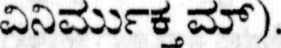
ವಿನಿರ್ಮುಕ್ತಮ್).
